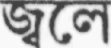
জ্বলে
